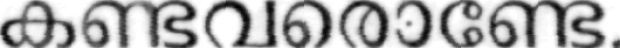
കണ്ടവരൊണ്ടേ.
